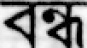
বন্ধ
